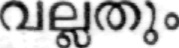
വല്ലതും
